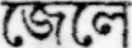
জেলে
